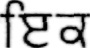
ਇਕ
